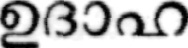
ഉദാഹ
